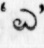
‘ಎ’
